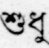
শুধু
